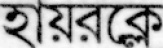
হায়রক্লে
